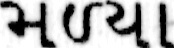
મળ્યા
